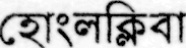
হোংলক্লিবা
